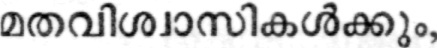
മതവിശ്വാസികള്‍ക്കും,
